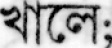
খালে;
